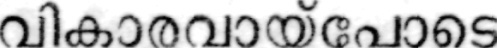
വികാരവായ്പോടെ
